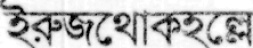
ইরুজথোকহল্লে
